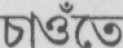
চাওঁতে
